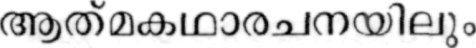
ആത്മകഥാരചനയിലും
